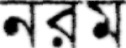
নরম
